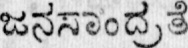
ಜನಸಾಂದ್ರತೆ
